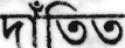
দাঁতিত
